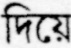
দিয়ে
